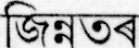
জিন্নতৰ
